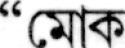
"মোক
